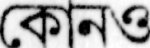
কোনও
